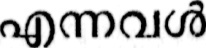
എന്നവള്‍
